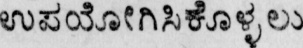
ಉಪಯೋಗಿಸಿಕೊಳ್ಳಲು
